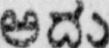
ಅದು
